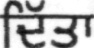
ਦਿੱਤਾ
